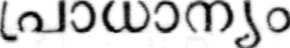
പ്രാധാന്യം
